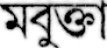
মবুক্তা
